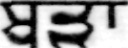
ਬੜਾ
